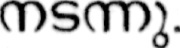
നടന്നു.
